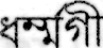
ধর্ম্মগী
